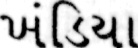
ખંડિયા
